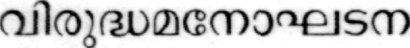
വിരുദ്ധമനോഘടന
